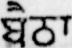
ਬੈਠਾ
